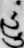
હું
